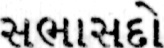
સભાસદો
